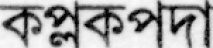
কপ্লকপদা
